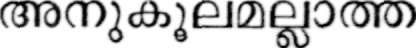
അനുകൂലമല്ലാത്ത
